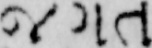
જગત
